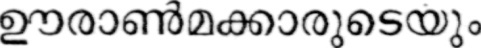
ഊരാണ്‍മക്കാരുടെയും
